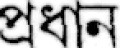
প্রধান
